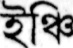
ইঞ্চি
